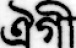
ঐগী
